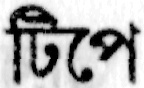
টিপে
